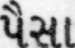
પૈસા
